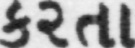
કરતા
